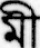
মী
